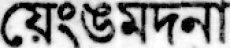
য়েংঙমদনা
